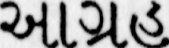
આગ્રહ
